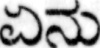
ಏನು
